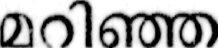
മറിഞ്ഞ
